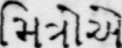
મિત્રોએ
